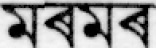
মৰমৰ
